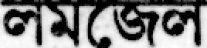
লমজেল
